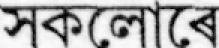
সকলোৰে
